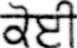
ਕੋਈ
